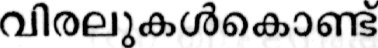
വിരലുകള്‍കൊണ്ട്
